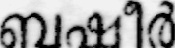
ബഷീര്‍
